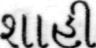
શાહી
